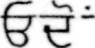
ਓਦੋਂ
